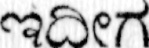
ಇದೀಗ
